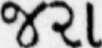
જરા
